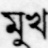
মুখ
